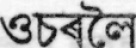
ওচৰলৈ
